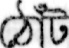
ঠোঁট
